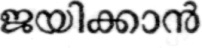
ജയിക്കാന്‍
